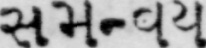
સમન્વય
